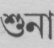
শুনা
